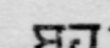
ਬਹਾ
